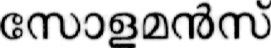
സോളമന്‍സ്
